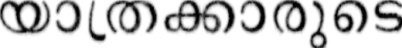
യാത്രക്കാരുടെ
